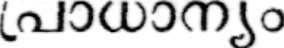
പ്രാധാന്യം
